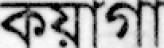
কয়াগা
